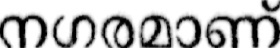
നഗരമാണ്
